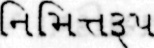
નિમિત્તરૂપ
